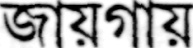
জায়গায়
